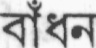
বাঁধন
